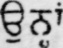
ਉਨ੍ਹਾਂ
